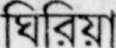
ঘিরিয়া
